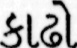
કાઢો
